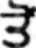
ਤੋਂ
